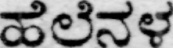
ಹೆಲೆನಳ
